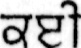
ਕਈ
